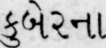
કુબેરના
